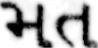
મત
